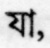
যা,
